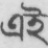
এই
